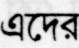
এদের
